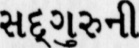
સદ્ગુરુની
